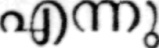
എന്നു
